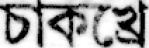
চাকখ্রে
